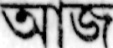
আজ
